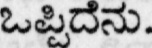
ಒಪ್ಪಿದೆನು.
